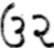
ઉર
